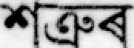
শত্রুৰ
